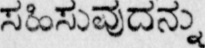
ಸಹಿಸುವುದನ್ನು
